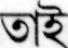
তাই
